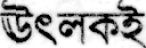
ঊৎলকই
